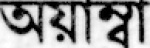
অয়াম্বা
